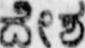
ದೇಶ
